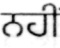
ਨਹੀਂ
